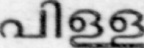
പിള്ള
